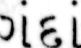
ગંદાં
